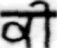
ਕੀ
